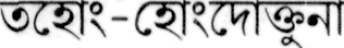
তহোং-হোংদোক্তুনা
